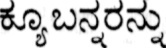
ಕ್ಯೂಬನ್ನರನ್ನು
